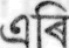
এৰি
